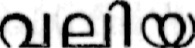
വലിയ
